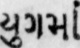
યુગમાં
